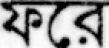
ফরে
